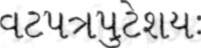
વટપત્રપુટેશયઃ
